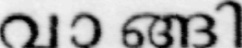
വാങ്ങി
